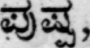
ಪುಷ್ಟ,
